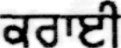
ਕਰਾਈ
